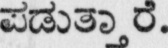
ಪಡುತ್ತಾರೆ.
